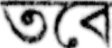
তবে
